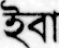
ইবা
